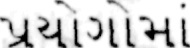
પ્રયોગોમાં
